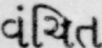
વંચિત
